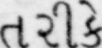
તરીકે
